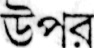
উপর
